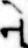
ને
